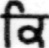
ਕਿ
